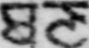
ਬਣ
